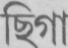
ছিগা
